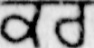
ਕਰ
